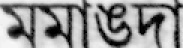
মমাঙদা
